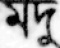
মদু
